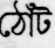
ঠোঁট
